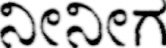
ನೀನೀಗ
